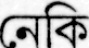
নেকি
